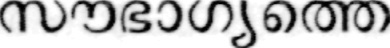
സൌഭാഗ്യത്തെ
